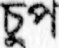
চুপ
